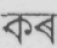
কৰ
